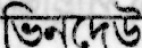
ভিনদেউ
